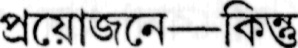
প্রয়োজনে--কিন্তু
